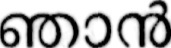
ഞാന്‍
